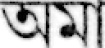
অমা
